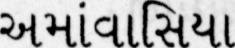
અમાંવાસિયા
